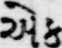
એક
